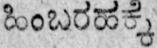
ಹಿಂಬರಹಕ್ಕೆ
